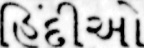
હિંદીઓ
